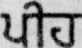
ਪੀਹ
